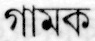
গামক
